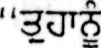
''ਤੁਹਾਨੂੰ
